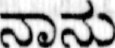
ನಾನು
